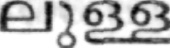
ലുള്ള
